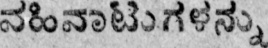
ವಹಿವಾಟುಗಳನ್ನು
